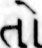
તો
